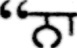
''ਨਾ
